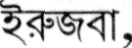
ইরুজবা,
